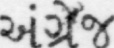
અંગ્રેજ
